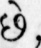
છે,
